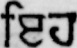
ਇਹ
